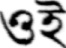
ওই
